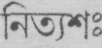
নিত্যশঃ
